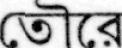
তৌরে
